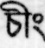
চীং
